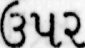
ઉપર
